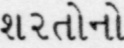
શરતોનો
